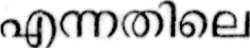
എന്നതിലെ
